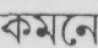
কমনে
